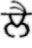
ਲੈ
